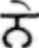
ਨੇ
